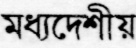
মধ্যদেশীয়
